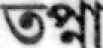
তপ্না
